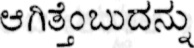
ಆಗಿತ್ತೆಂಬುದನ್ನು
